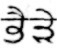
ਭੈੜੇ
